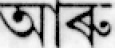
আৰু
